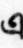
এ
